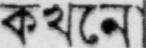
কখনো
